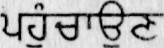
ਪਹੁੰਚਾਉਣ
